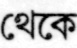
থেকে
